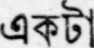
একটা
